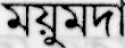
ময়ুমদা
